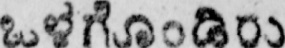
ಒಳಗೊಂಡಿರು
